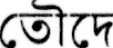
তৌদে
